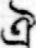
ঐ
